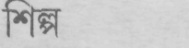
শিল্প
